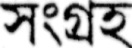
সংগ্রহ
